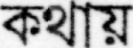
কথায়
